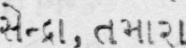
સેન્દ્રા,તમારા
